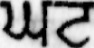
ਘਟ
